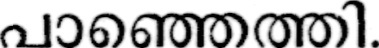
പാഞ്ഞെത്തി.
